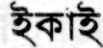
ইকাই
